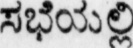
ಸಭೆಯಲ್ಲಿ
